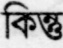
কিন্তু
